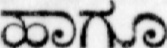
ಹಾಗೂ
